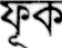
ফূক
